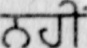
ਨਹੀਂ
